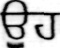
ਉਹ
